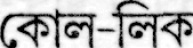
কোল-লিক
